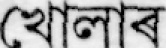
খোলাৰ
